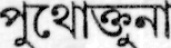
পুথোক্তুনা
